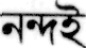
নন্দই
